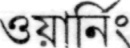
ওয়ার্নিং
